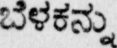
ಬೆಳಕನ್ನು
